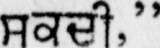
ਸਕਦੀ,''
